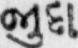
જુદા
